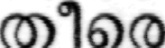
തീരെ
